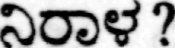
ನಿರಾಳ?
